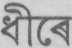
ধীৰে
